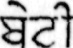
ਬੇਟੀ
